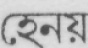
হেনয়
